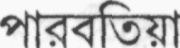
পারবতিয়া
